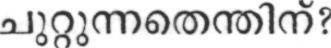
ചുറ്റുന്നതെന്തിന്?
